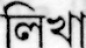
লিখা
